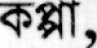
কপ্পা,
